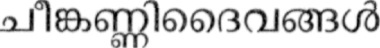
ചീങ്കണ്ണിദൈവങ്ങള്‍
